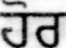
ਹੋਰ
